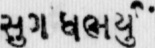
સુગધભર્યું
